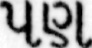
પણ
